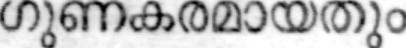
ഗുണകരമായതും
